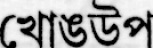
খোঙউপ
